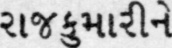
રાજકુમારીને
